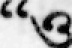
“ও
